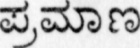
ಪ್ರಮಾಣ
